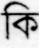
কি
